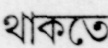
থাকতে
